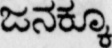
ಜನಕ್ಕೂ
